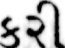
કરી
